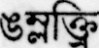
ঙম্লক্ত্রি
